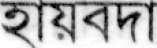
হায়বদা
